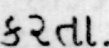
કરતા.
